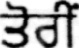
ਤੋਰੀਂ
